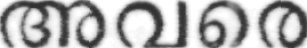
അവരെ
